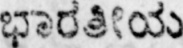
ಭಾರತೀಯ
